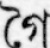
গৈ
